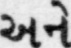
અને
